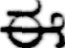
ಈ
